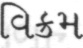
વિક્રમ
